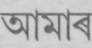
আমাৰ
